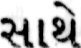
સાથે
